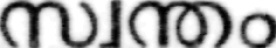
സ്വന്തം
